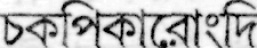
চকপিকারোংদি
